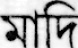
মাদি
